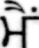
ਮੈਂ
